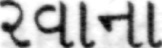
રવાના
